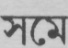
সমে
